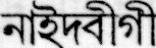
নাইদবী
